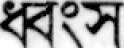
ধ্বংস
